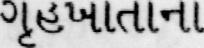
ગૃહખાતાના
